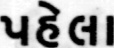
પહેલા
